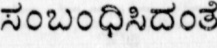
ಸಂಬಂಧಿಸಿದಂತೆ
